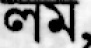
লম,
